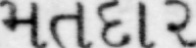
મતદાર
